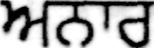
ਅਨਾਰ
